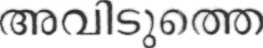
അവിടുത്തെ
